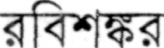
রবিশঙ্কর
